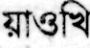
য়াওখি
